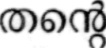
തന്റെ
